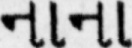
નાના
